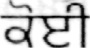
ਕੋਈ
